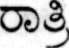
ರಾತ್ರಿ
